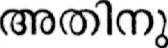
അതിനു
